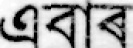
এবাৰ
